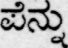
ಪೆನ್ನು
